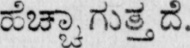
ಹೆಚ್ಚಾಗುತ್ತದೆ.
